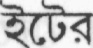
ইটের
